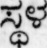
ಸ್ಥಳ
